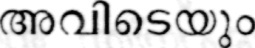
അവിടെയും
